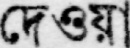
দেওয়া
